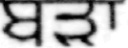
ਬੜਾਾ
